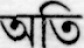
অতি
